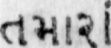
તમારાં
